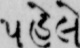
પહેલે
